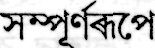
সম্পূর্ণৰূপে
